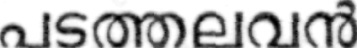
പടത്തലവന്‍
